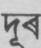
দূৰ
